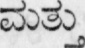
ಮತ್ತು
